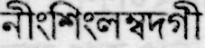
নীংশিংলম্বদগী
